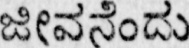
ಜೀವನೆಂದು
